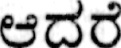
ಆದರೆ
